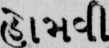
હોમવી
